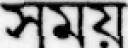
সময়
